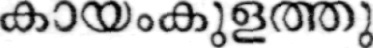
കായംകുളത്തു
